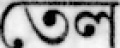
তেল
